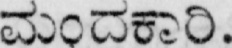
ಮಂದಕಾರಿ.
